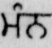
ਮੰਨ
